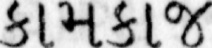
કામકાજ
